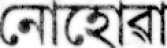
নোহোৱা
